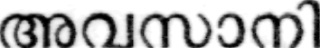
അവസാനി
